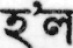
হ'ল
